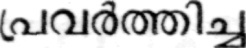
പ്രവര്‍ത്തിച്ച
